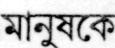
মানুষকে
